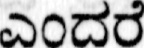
ಎಂದರೆ
